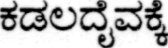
ಕಡಲದೈವಕ್ಕೆ
